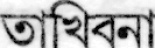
তাখিবনা
